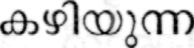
കഴിയുന്ന
